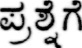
ಪ್ರಶ್ನೆಗೆ
